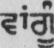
ਵਾਂਗੂੰ
